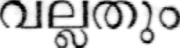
വല്ലതും
